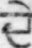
ਦੇ
